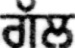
ਗੱਲ
